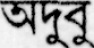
অদুবু
